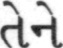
તેને
